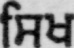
ਸਿਖ
